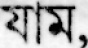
যাম,
